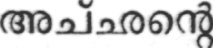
അച്ഛന്റെ
